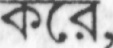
করে,
